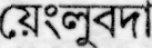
য়েংলুবদা
